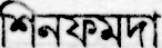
শিনফমদা
